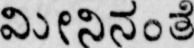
ಮೀನಿನಂತೆ
